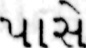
પાસે
